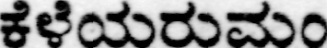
ಕೆಳೆಯರುಮಂ
